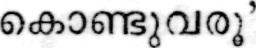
കൊണ്ടുവരൂ’
